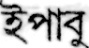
ইপাবু
